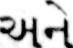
અને
